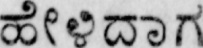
ಹೇಳಿದಾಗ
